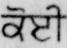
ਕੋਈ
